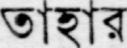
তাহার
